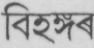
বিহঙ্গৰ
